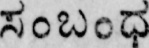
ಸಂಬಂಧ
